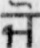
ਜੋ
